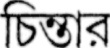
চিন্তার
